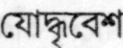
যোদ্ধৃবেশ
